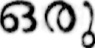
ഒരു
